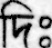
দিঃ
